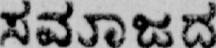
ಸಮಾಜದ
